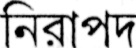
নিরাপদ
